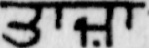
ਤਾਜ਼ਾ
